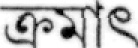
ক্ৰমাৎ
